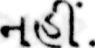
નહીં.
